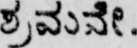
ಶ್ರಮವೇ.
